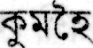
কুমহৈ
